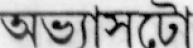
অভ্যাসটো
